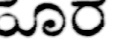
ಹೊರ
